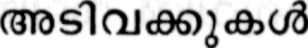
അടിവക്കുകള്‍
